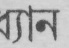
ধ্যান
